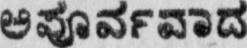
ಅಪೂರ್ವವಾದ
